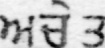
ਅਚੇਤ
